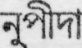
নুপীদা
